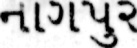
નાગપુર
